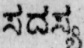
ಸದಸ್ಯ
